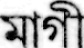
মাগী
